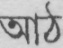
আঠ
